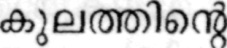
കുലത്തിന്റെ
